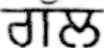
ਗੱਲ
